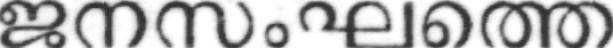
ജനസംഘത്തെ
